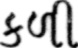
કળી
